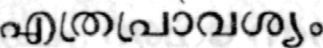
എത്രപ്രാവശ്യം
